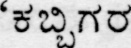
‘ಕಬ್ಬಿಗರ
